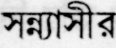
সন্ন্যাসীর
